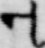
ન
